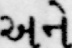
અને
